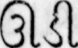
ઊડી
